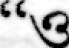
“ও
